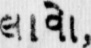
લાવો,
